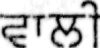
ਵਾਲੀ
